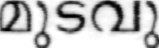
മുടവു
